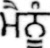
ਮੈਨੂੰ
